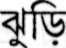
ঝুড়ি
